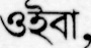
ওইবা,
